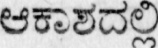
ಆಕಾಶದಲ್ಲಿ
